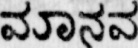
ಮಾನವ
